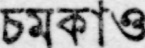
চমকাও
